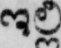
ಇಲ್ಲಿ
